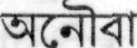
অনৌবা
